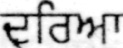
ਦਰਿਆ
